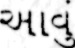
આવું
